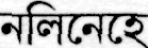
নলিনেহে
